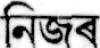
নিজৰ
